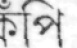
কঁপি
